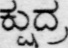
ಕ್ಷುದ್ರ
